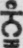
ਨੂੰ
